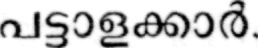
പട്ടാളക്കാര്‍.
